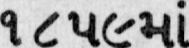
૧૮૫૯માં
